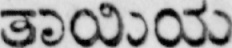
ತಾಯಿಯ
